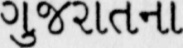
ગુજરાતના
